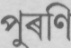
পুৰণি
